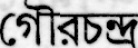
গৌরচন্দ্র
